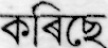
কৰিছে
